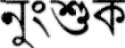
নুংশুক
